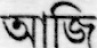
আজি
